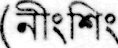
(নীংশিং
